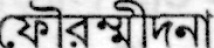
ফৌরম্মীদনা
